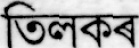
তিলকৰ
